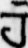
ਹੋ
